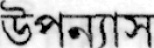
উপন্যাস
